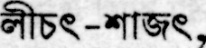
লীচৎ-শাজৎ,
